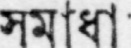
সমাধা
